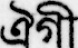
ঐগী
